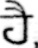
ਹੈ,
